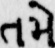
તમે
